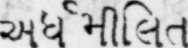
અર્ધમીલિત
